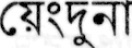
য়েংদুনা
